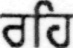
ਰਹਿ
